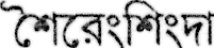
শৈরেংশিংদা
